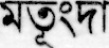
মতূংদা
